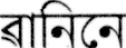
ৱানিনে
